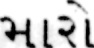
મારો
